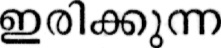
ഇരിക്കുന്ന
